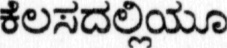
ಕೆಲಸದಲ್ಲಿಯೂ
